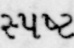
સ્પષ્ટ
